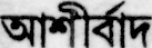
আশীর্বাদ
